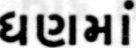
ધણમાં
